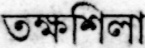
তক্ষশিলা
